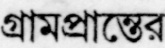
গ্রামপ্রান্তের
